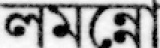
লমন্নো
